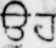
ਉਹ
